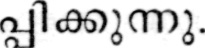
പ്പിക്കുന്നു.
